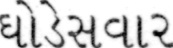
ઘોડેસવાર
